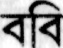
ববি
